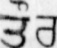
ਤੌਰ
